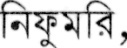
নিফুমরি,
